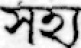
সহ্য
